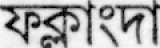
ফক্লাংদা
